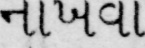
નાખવા
